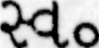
સ્વ.
